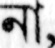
না,
